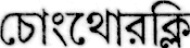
চোংথোরক্লি
